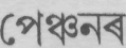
পেঞ্চনৰ
